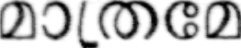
മാത്രമേ
